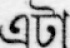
এটা
